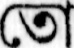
তো
